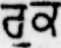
ਰੁਕ
